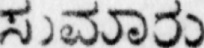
ಸುಮಾರು
